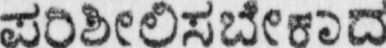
ಪರಿಶೀಲಿಸಬೇಕಾದ
